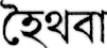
হৈথবা
